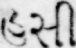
હસી
